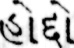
હોદ્દો
